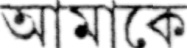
আমাকে
